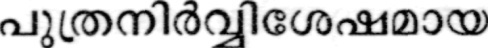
പുത്രനിര്‍വ്വിശേഷമായ
